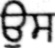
ਉਸ
